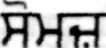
ਸੋਮਜ਼
